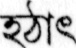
হঠাৎ
